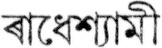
ৰাধেশ্যামী
